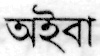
অইবা
